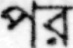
পর
